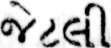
જેટલી
